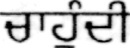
ਚਾਹੁੰਦੀ
